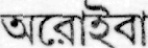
অরোইবা
